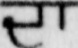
ਦਾ
